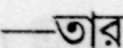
–তার
